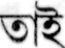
তাই
